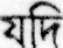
যদি
